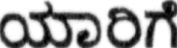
ಯಾರಿಗೆ
